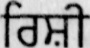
ਰਿਸ਼ੀ
